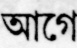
আগে
